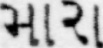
મારા
